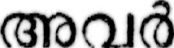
അവര്‍
